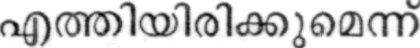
എത്തിയിരിക്കുമെന്ന്
